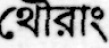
থৌরাং
